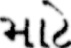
માટે
